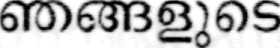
ഞങ്ങളുടെ
